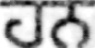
ਹਨ
